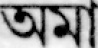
অমা
